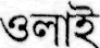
ওলাই
